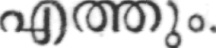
എത്തും.
